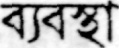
ব্যবস্থা
